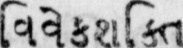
વિવેકશક્તિ
